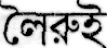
লৈরুই
